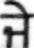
ਜੇ
